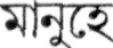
মানুহে
